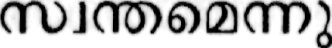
സ്വന്തമെന്നു
